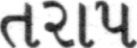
તરાપ
